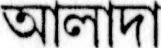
আলাদা
